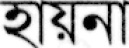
হায়না
